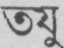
তযু
